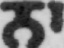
ਨਾ
